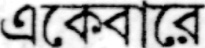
একেবারে
